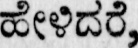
ಹೇಳಿದರೆ,
